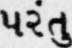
પરંતુ
